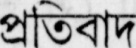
প্রতিবাদ
